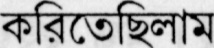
করিতেছিলাম
